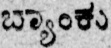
ಬ್ಯಾಂಕು
